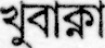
খুবাক্না
